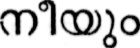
നീയും
